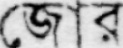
জোর
